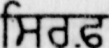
ਸਿਰਫ਼
